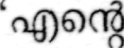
‘എന്റെ
